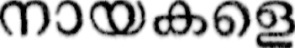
നായകളെ
